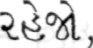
રહેજો,
